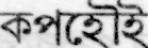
কপহৌই
